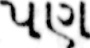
પણ
